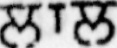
ਲਾਲ
